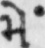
મેં
